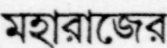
মহারাজের
